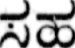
ಸಹ
